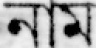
নাম
